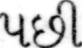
પછી
